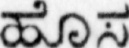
ಹೊಸ
